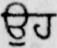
ਉਹ
